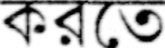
করতে
